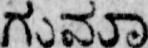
ಗುಮಾ
